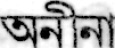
অনীনা
